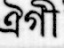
ঐগী
